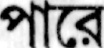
পারে
